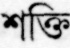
শক্তি
